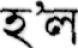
হ'ল
